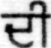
ਦੀ
